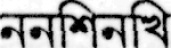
ননশিনখি
